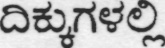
ದಿಕ್ಕುಗಳಲ್ಲಿ
